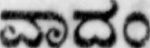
ವಾದಂ
